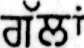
ਗੱਲਾਂ
